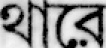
থারে
